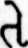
તે
